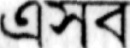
এসব
